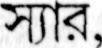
স্যার,
